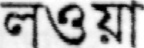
লওয়া
